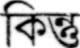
কিন্তু
